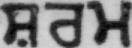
ਸ਼ਰਮ
